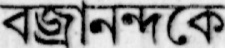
বজ্রানন্দকে
